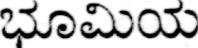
ಭೂಮಿಯ
